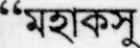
“মহাকসু
